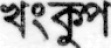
খংকুপ
